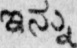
ಇನ್ನು
